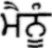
ਮੈਨੂੰ
